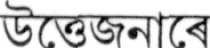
উত্তেজনাৰে
